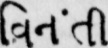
વિનંતી
